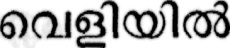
വെളിയില്‍
